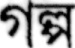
গল্প
